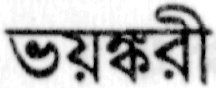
ভয়ঙ্করী
